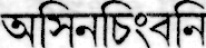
অসিনচিংবনি
